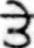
ਤੇ
